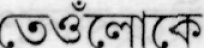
তেওঁলোকে
